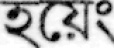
হয়েং
